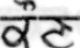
ਕੌਣ
